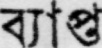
ব্যাপ্ত
